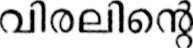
വിരലിന്റെ
